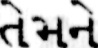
તેમને
